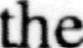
the
